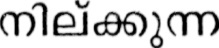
നില്ക്കുന്ന
